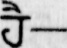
ਹੈ-
